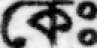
কেঃ
